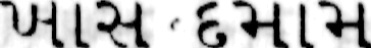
ખાસ-દમામ
